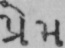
પ્રેમ
